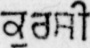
ਕੁਰਸੀ
